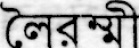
লৈরম্মী
